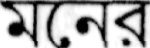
মনের
